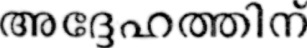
അദ്ദേഹത്തിന്
